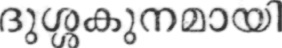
ദുശ്ശകുനമായി
